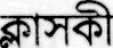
ক্লাসকী
